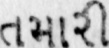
તમારી
